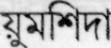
য়ুমশিদা
